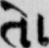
તો
